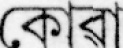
কোৱা
